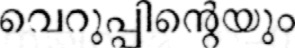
വെറുപ്പിന്റെയും
